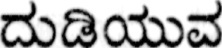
ದುಡಿಯುವ
